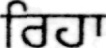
ਰਿਹਾ
